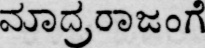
ಮಾದ್ರರಾಜಂಗೆ
